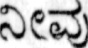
ನೀವು
